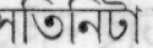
সতিনিটা
